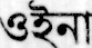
ওইনা
